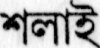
শলাই
